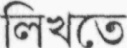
লিখতে
